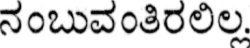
ನಂಬುವಂತಿರಲಿಲ್ಲ.
